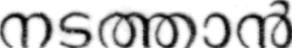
നടത്താന്‍
